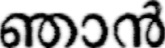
ഞാന്‍
